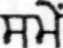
ਸਮੇਂ
